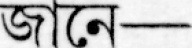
জানে-
